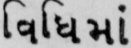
વિધિમાં
